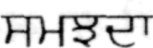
ਸਮਝਦਾ
